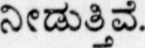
ನೀಡುತ್ತಿವೆ.
